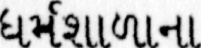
ધર્મશાળાના
